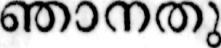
ഞാനതു
